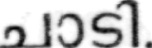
ചാടി.
